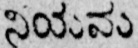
ನಿಯಮ
